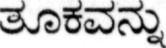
ತೂಕವನ್ನು
